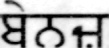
ਬੇਨਜ਼
